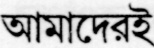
আমাদেরই
